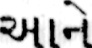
આને
